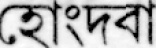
হোংদবা
